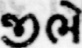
જીભે
